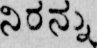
ನಿರನ್ನು
